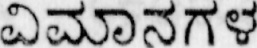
ವಿಮಾನಗಳ
